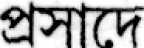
প্রসাদে
